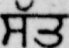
ਸੱਤ
